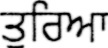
ਤੁਰਿਆ
